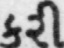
કરી
